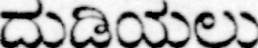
ದುಡಿಯಲು
